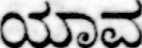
ಯಾವ
